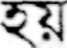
হয়
